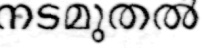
നടമുതല്‍
